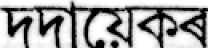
দদায়েকৰ
